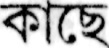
কাছে
